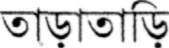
তাড়াতাড়ি
